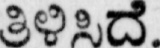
ತಿಳಿಸಿದೆ.
